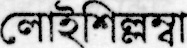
লোইশিল্লম্বা
